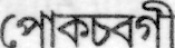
পোকচবগী
